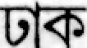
ঢাক
